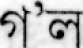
গ'ল
